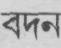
বদন
